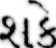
શકે
